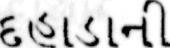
દહાડાની
